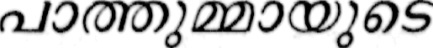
പാത്തുമ്മായുടെ
